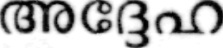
അദ്ദേഹ
